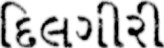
દિલગીરી
